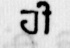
ਹੀ
